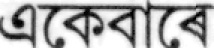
একেবাৰে
